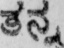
ತನ್ನ
